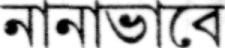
নানাভাবে
